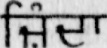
ਜ਼ਿੰਦਾ
